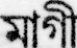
মাগী
